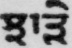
ਝਾੜੇ
